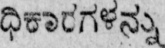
ಧಿಕಾರಗಳನ್ನು
